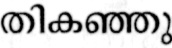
തികഞ്ഞു
